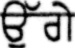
ਉੱਗੇ
